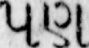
પણ
